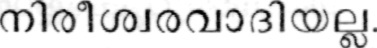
നിരീശ്വരവാദിയല്ല.
